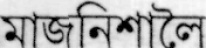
মাজনিশালৈ
